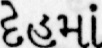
દેહમાં
